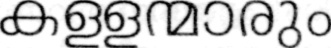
കള്ളന്മാരും
